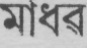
মাধৱ
